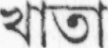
খাতা
